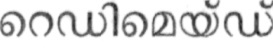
റെഡിമെയ്ഡ്
